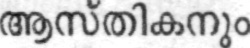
ആസ്തികനും
